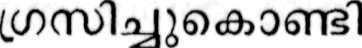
ഗ്രസിച്ചുകൊണ്ടി
